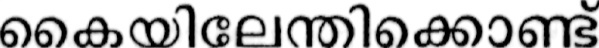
കൈയിലേന്തിക്കൊണ്ട്
